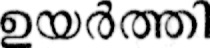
ഉയര്‍ത്തി
